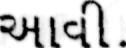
આવી.
